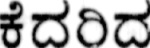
ಕೆದರಿದ
